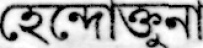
হেন্দোক্তুনা
